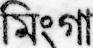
মিংগা
